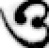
ও
